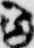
છે
